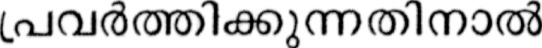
പ്രവര്‍ത്തിക്കുന്നതിനാല്‍
